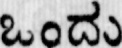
ಒಂದು
